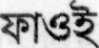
ফাওই
